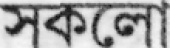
সকলো
